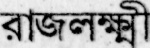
রাজলক্ষ্মী
